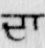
ਦਾ
